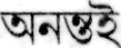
অনন্তই
